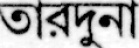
তারদুনা
